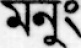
মনুং
